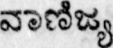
ವಾಣಿಜ್ಯ
